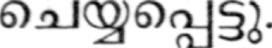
ചെയ്യപ്പെട്ടു.
